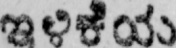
ಇಳಿಕೆಯ
